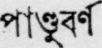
পাণ্ডুবর্ণ
